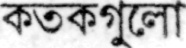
কতকগুলো
